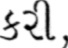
કરી,
